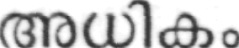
അധികം
